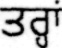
ਤਰ੍ਹਾਂ
